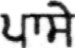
ਪਾਸੇ
